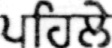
ਪਹਿਲੇ
